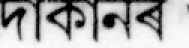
দোকানৰ
